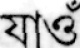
যাওঁ
